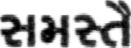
સમસ્તૈ
